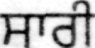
ਸਾਰੀ
